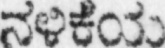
ನಳಿಕೆಯ
